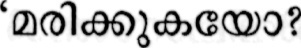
'മരിക്കുകയോ?
